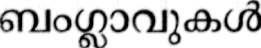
ബംഗ്ലാവുകള്‍
